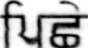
ਪਿਛੇ
